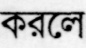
করলে
